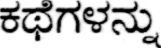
ಕಥೆಗಳನ್ನು
